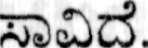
ಸಾವಿದೆ.
